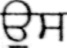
ਉਸ
